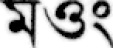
মওং
